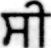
ਸੀ
